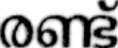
രണ്ട്
